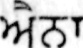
ਐਨਾ
